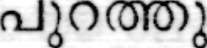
പുറത്തു
